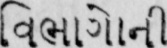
વિભાગોની
